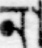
না
